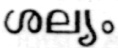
ശല്യം
